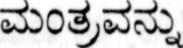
ಮಂತ್ರವನ್ನು
